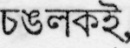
চঙলকই
